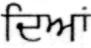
ਦਿਆਂ
